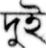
দুই
